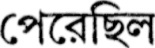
পেরেছিল
